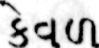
કેવળ
